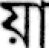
য়া
